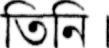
তিনি।
